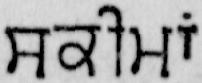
ਸਕੀਮਾਂ
